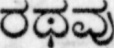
ರಥವು
